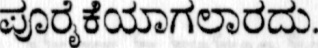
ಪೂರೈಕೆಯಾಗಲಾರದು.
